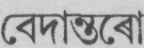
বেদান্তৰো
